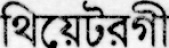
থিয়েটরগী
